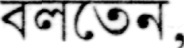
বলতেন,
